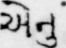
એનું
